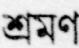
শ্রমণ
